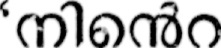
‘നിന്റെ
